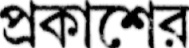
প্রকাশের
